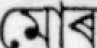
মোৰ
